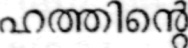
ഹത്തിന്റെ
